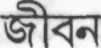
জীবন
